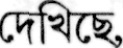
দেখিছে,
